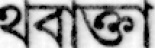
থবাক্তা
